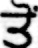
ਤੋਂ
